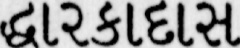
દ્વારકાદાસ
